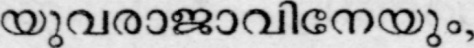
യുവരാജാവിനേയും,
